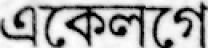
একেলগে
